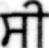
ਸੀ
